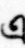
এ
